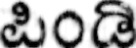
ಪಿಂಡಿ
